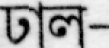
ঢাল-
